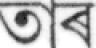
তাৰ
